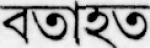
বতাহত
